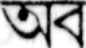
অব
